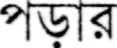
পড়ার
